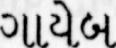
ગાયેબ
